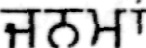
ਜਨਮਾਂ
